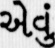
એવું
